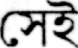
সেই
